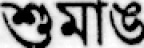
শুমাঙ
